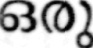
ഒരു
